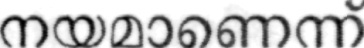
നയമാണെന്ന്
